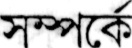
সম্পর্কে
